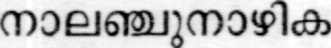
നാലഞ്ചുനാഴിക
